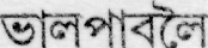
ভালপাবলৈ
